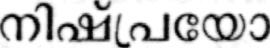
നിഷ്പ്രയോ
